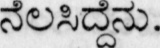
ನೆಲಸಿದ್ದೆನು.
